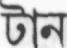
টান
